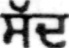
ਸੱਦ
